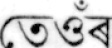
তেওঁৰ
